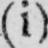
(i)
